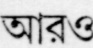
আরও
